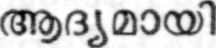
ആദ്യമായി
